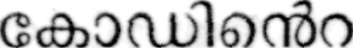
കോഡിന്റെ
